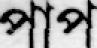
পাপ
